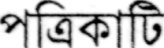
পত্রিকাটি
